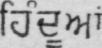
ਹਿੰਦੂਆਂ
